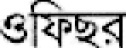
ওফিছর
